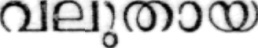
വലുതായ
